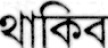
থাকিব
